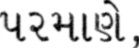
પરમાણે,
